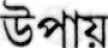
উপায়
